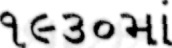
૧૯૩૦માં
